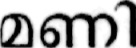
മണി
